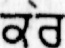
ਕਰ
